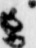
હું
